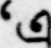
‘এ
